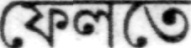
ফেলতে
